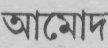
আমোদ
